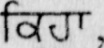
ਕਿਹਾ,
